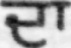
ਦਾ
